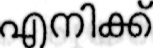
എനിക്ക്
